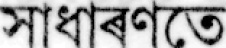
সাধাৰণতে
